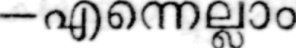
-എന്നെല്ലാം
